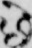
છે
